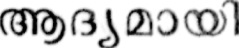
ആദ്യമായി
